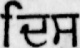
ਦਿਸ
